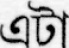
এটা
